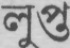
লুপ্ত
